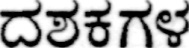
ದಶಕಗಳ
